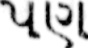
પણ
